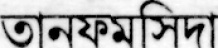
তানফমসিদা
